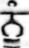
ਨੂੰ
